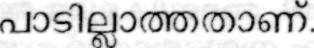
പാടില്ലാത്തതാണ്.
